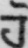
ਹੋ
